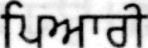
ਪਿਆਰੀ
